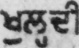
ਖੁਲ੍ਹਦੀ
